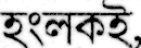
হংলকই,
